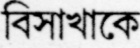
বিসাখাকে
